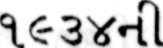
૧૯૩૪ની
